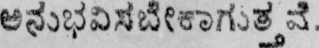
ಅನುಭವಿಸಬೇಕಾಗುತ್ತವೆ.
